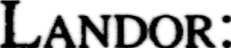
LANDOR:
